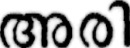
അരി
